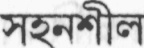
সহনশীল
